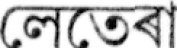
লেতেৰা
